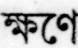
ক্ষণে
